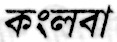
কংলবা
